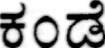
ಕಂಡೆ
